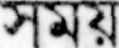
সময়
